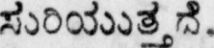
ಸುರಿಯುತ್ತದೆ.
